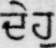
ਦੇਹੁ
